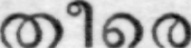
തീരെ
